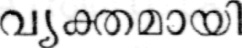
വ്യക്തമായി
